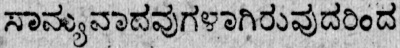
ಸಾಮ್ಯವಾದವುಗಳಾಗಿರುವುದರಿಂದ
